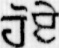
ਹੋਏ
